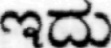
ಇದು
